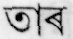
তাৰ
